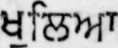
ਖੁਲਿਆ
